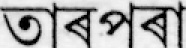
তাৰপৰা
